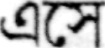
এসে
